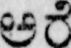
ಅರೆ
